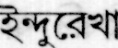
ইন্দুরেখা
